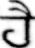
ਹੈ
